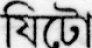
যিটো
